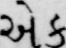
એક
